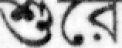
শুরে
